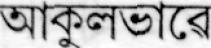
আকুলভাৱে
